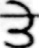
ਤੇ
